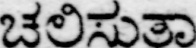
ಚಲಿಸುತಾ
